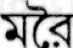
মরৈ
